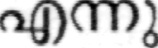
എന്നു
